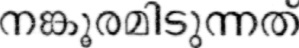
നങ്കൂരമിടുന്നത്
